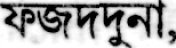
ফজদদুনা,
